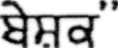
ਬੇਸ਼ਕ''
